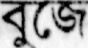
বুজে
